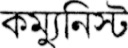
কম্যুনিস্ট
